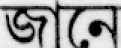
জানে
